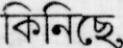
কিনিছে,
